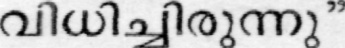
വിധിച്ചിരുന്നു”
